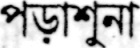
পড়াশুনা
